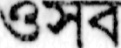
ওসব
